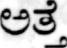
ಅತ್ತೆ
